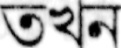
তখন
